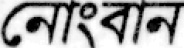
নোংবান
